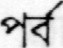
পর্ব
